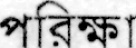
পরিক্ষা
